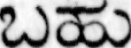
ಬಹು
